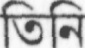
তিনি
